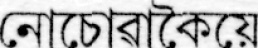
নোচোৱাকৈয়ে
